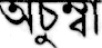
অচুম্বা
